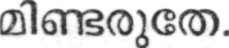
മിണ്ടരുതേ.
